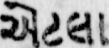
એટલા
